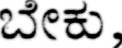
ಬೇಕು,
